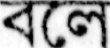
বলে
